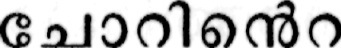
ചോറിന്റെ
